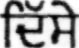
ਦਿੱਸੇ
